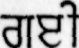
ਗਈ
